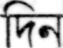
দিন
